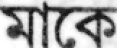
মাকে
